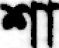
শা
